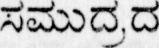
ಸಮುದ್ರದ
